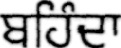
ਬਹਿੰਦਾ
